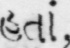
હતાં.
